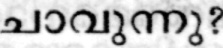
ചാവുന്നു?
